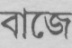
বাজে
